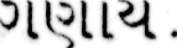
ગણાય.
